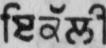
ਇਕੱਲੀ
